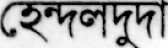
হেন্দলদুদা
